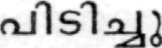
പിടിച്ചു
